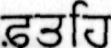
ਫ਼ਤਹਿ
